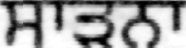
ਸਾੜਨਾ
